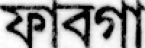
ফাবগা
